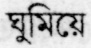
ঘুমিয়ে
